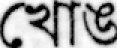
খোঙ
